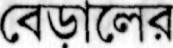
বেড়ালের
